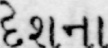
દેશના
